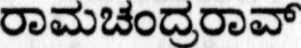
ರಾಮಚಂದ್ರರಾವ್
